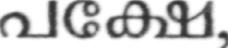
പക്ഷേ,
